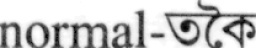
normal-তকৈ
